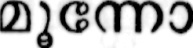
മൂന്നോ
